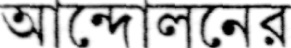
আন্দোলনের
